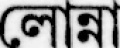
লোন্না
